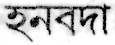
হনবদা
